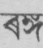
ৰঙ্গ
